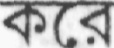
করে
